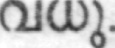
വധു.
